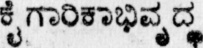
ಕೈಗಾರಿಕಾಭಿವೃದ್ಧ
